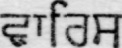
ਵਾਰਿਸ
